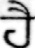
ਹੈ
